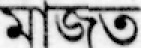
মাজত
